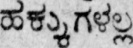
ಹಕ್ಕುಗಳಲ್ಲ
